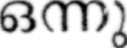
ഒന്നു
